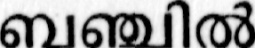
ബഞ്ചില്‍
